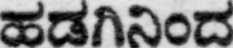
ಹಡಗಿನಿಂದ
